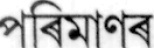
পৰিমাণৰ
